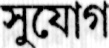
সুযোগ
